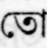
তো
